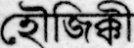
হৌজিক্কী
